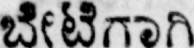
ಬೇಟೆಗಾಗಿ
